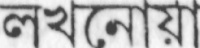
লখনোয়া
